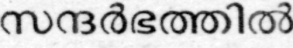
സന്ദര്‍ഭത്തില്‍
